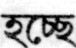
হচ্ছে
